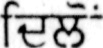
ਦਿਲੋਂ
